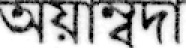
অয়াম্বদা
